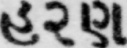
હરણ
